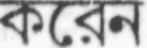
করেন
